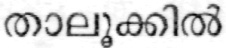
താലൂക്കില്‍
